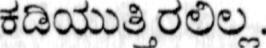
ಕಡಿಯುತ್ತಿರಲಿಲ್ಲ.
